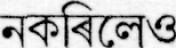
নকৰিলেও
